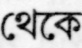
থেকে
